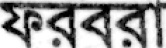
ফরবরা
